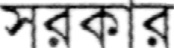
সরকার
